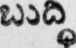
ಬುದ್ಧಿ
